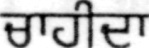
ਚਾਹੀਦਾ
